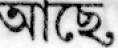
আছে,
